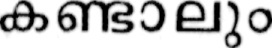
കണ്ടാലും
